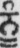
ਨੂੰ
